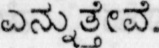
ಎನ್ನುತ್ತೇವೆ.
